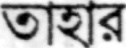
তাহার
